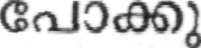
പോക്കു
